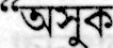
“অসুক
